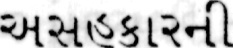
અસહકારની
